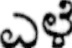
ಎಳೆ
